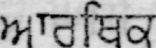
ਆਰਥਿਕ
